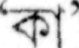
‘কা’
